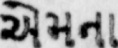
એમના
